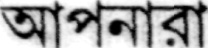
আপনারা
